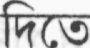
দিতে
